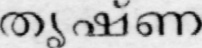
തൃഷ്ണ
